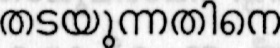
തടയുന്നതിനെ
